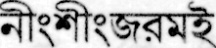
নীংশীংজরমই
